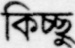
কিচ্ছু
